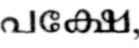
പക്ഷേ,
